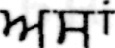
ਅਸਾਂ
